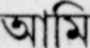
আমি
